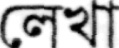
লেখা
